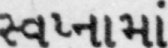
સ્વપ્નામાં
